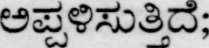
ಅಪ್ಪಳಿಸುತ್ತಿದೆ;
